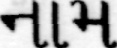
નામ
